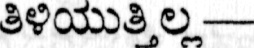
ತಿಳಿಯುತ್ತಿಲ್ಲ-
